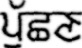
ਪੁੱਛਣ
